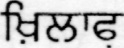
ਖ਼ਿਲਾਫ਼
